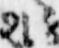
શકે
